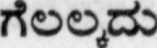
ಗೆಲಲ್ಕದು
